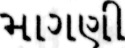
માગણી
